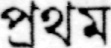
প্রথম
